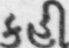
કહી
